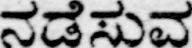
ನಡೆಸುವ
